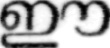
ഈ
